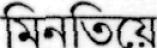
মিনতিয়ে
